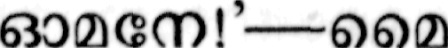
ഓമനേ!’-മൈ
